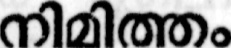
നിമിത്തം
